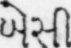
બેસી
